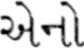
એનો
